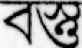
বস্তু
